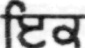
ਇਕ
